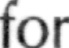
for
